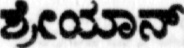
ಶ್ರೇಯಾನ್
